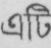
এটি
